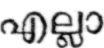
എല്ലാ
